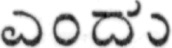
ಎಂದು
